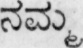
ನಮ್ಮ
